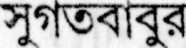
সুগতবাবুর
